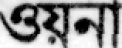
ওয়না
